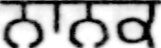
ਨਾਨਕ
